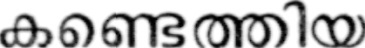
കണ്ടെത്തിയ
